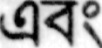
এবং
